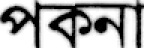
পকনা
